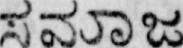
ಸಮಾಜ
